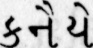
કનૈયે
